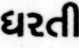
ધરતી
